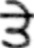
ਤੇ
